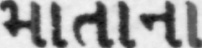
માતાના
